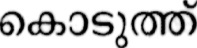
കൊടുത്ത്
